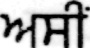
ਅਸੀਂ
